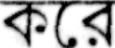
করে
